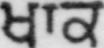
ਖਾਕ
